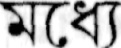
মধ্যে
